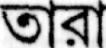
তারা
